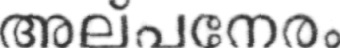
അല്പനേരം
